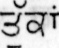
ਤੁੱਕਾਂ
